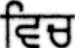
ਵਿਚ
